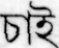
চাই
